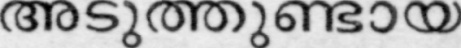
അടുത്തുണ്ടായ
